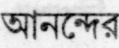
আনন্দের
